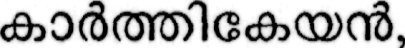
കാര്‍ത്തികേയന്‍,
